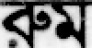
রুম
